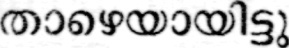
താഴെയായിട്ടു
